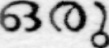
ഒരു
